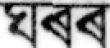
ঘৰৰ
